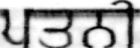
ਪਤਨੀ
